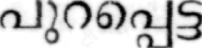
പുറപ്പെട്ട
